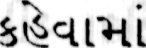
કહેવામાં
